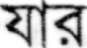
যার
